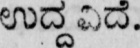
ಉದ್ದವಿದೆ.
